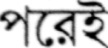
পরেই
